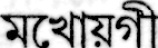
মখোয়গী
